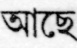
আছে
